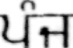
ਪੰਜ
